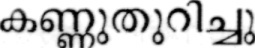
കണ്ണുതുറിച്ചു
